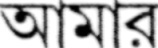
আমার
